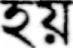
হয়
